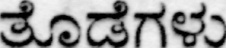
ತೊಡೆಗಳು
